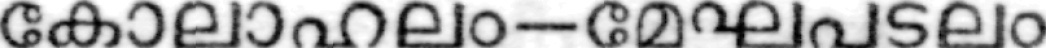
കോലാഹലം-മേഘപടലം
